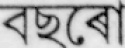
বছৰো
